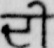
ਦੀ
